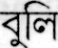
বুলি
